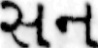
સન
